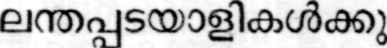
ലന്തപ്പടയാളികള്‍ക്കു
